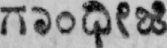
ಗಾಂಧೀಜಿ
